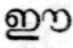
ഈ
